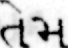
તેમ
